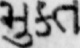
મુક્ત
